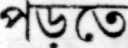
পড়তে
